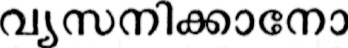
വ്യസനിക്കാനോ
